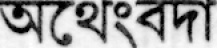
অথেংবদা
